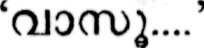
‘വാസൂ....’
